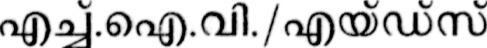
എച്ച്.ഐ.വി./എയ്ഡ്സ്
